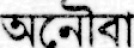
অনৌবা
